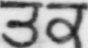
ਤਕ
